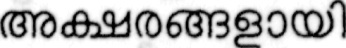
അക്ഷരങ്ങളായി
